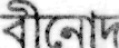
বীনোদ
